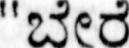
“ಬೇರೆ
